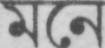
মনে
